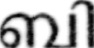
ബി
